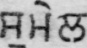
ਸੁਮੇਲ
